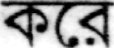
করে
